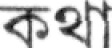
কথা
